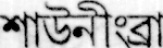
শাউনীংব্রা
